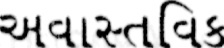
અવાસ્તવિક
